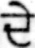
ਦੇ
